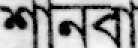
শানবা
